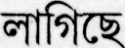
লাগিছে
